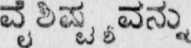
ವೈಶಿಷ್ಟ್ಯವನ್ನು
